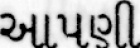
આપણી
